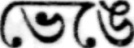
ভেঙে
